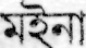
মইনা
